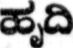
ಹೃದಿ
